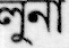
লুনা
